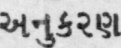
અનુકરણ
